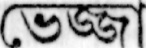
ভেজ্জা
